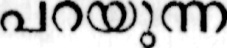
പറയുന്ന
